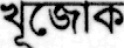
খূজোক
